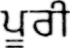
ਪੂਰੀ
